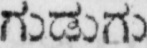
ಗುಡುಗು
